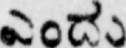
ಎಂದು
